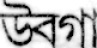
উবগা
